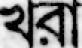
খরা
